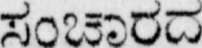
ಸಂಚಾರದ
